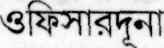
ওফিসারদূনা
